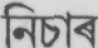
নিচাৰ
